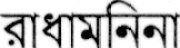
রাধামনিনা
